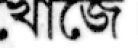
খোজে
